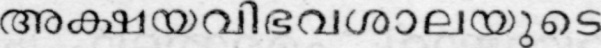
അക്ഷയവിഭവശാലയുടെ
